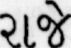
રાજે
